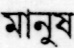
মানুষ
